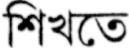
শিখতে
